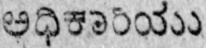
ಅಧಿಕಾರಿಯು
